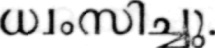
ധ്വംസിച്ചു.
